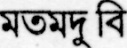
মতমদু
